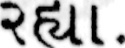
રહ્યા.
